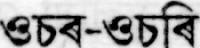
ওচৰ-ওচৰি
